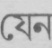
যেন
